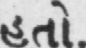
હતો.
